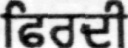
ਫਿਰਦੀ
